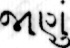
જાણું
